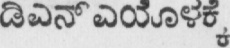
ಡಿಎನ್ಎಯೊಳಕ್ಕೆ
